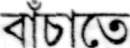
বাঁচাতে
